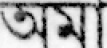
অমা
